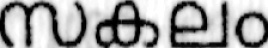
സകലം
